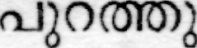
പുറത്തു
